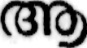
ആ
